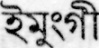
ইমুংগী
